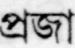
প্রজা
